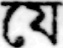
যে
